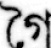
গৈ
